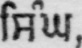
ਸਿੰਘ,
